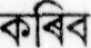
কৰিব
